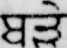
ਬੜੇ
